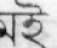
মই
